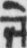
ਜੇ
